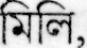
মিলি,
